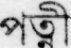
পত্নী
